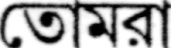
তোমরা
